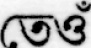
তেওঁ
